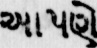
આપણે
